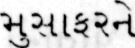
મુસાફરને
